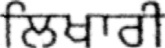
ਲਿਖਾਰੀ
